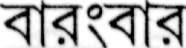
বারংবার
